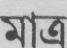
মাত্ৰ
